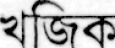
খজিক
